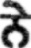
ਨੇ
